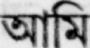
আমি
